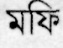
মফি
